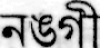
নঙগী
